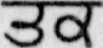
ਤਕ
